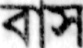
বাস
